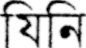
যিনি
